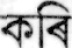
কৰি
